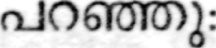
പറഞ്ഞു:
